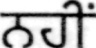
ਨਹੀਂ
